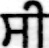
ਸੀ
